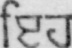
ਇਹ
